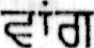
ਵਾਂਗ
